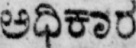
ಅಧಿಕಾರ
